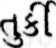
તુર્કી
